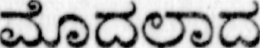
ಮೊದಲಾದ
